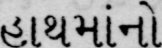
હાથમાંનો
